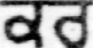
ਕਰ
